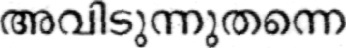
അവിടുന്നുതന്നെ
